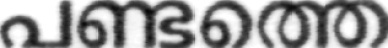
പണ്ടത്തെ
